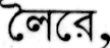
লৈরে,
